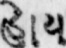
હોય
